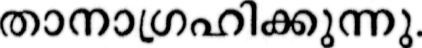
താനാഗ്രഹിക്കുന്നു.
